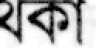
থকা
